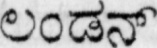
ಲಂಡನ್
